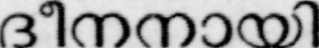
ദീനനായി
